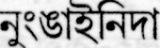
নুংঙাইনিদা
